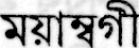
ময়াম্বগী
